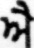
ਐ
